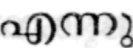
എന്നു
